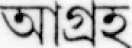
আগ্ৰহ
